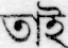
তাই
